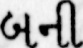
બની
